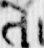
તો
